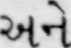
અને
